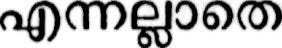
എന്നല്ലാതെ
